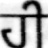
ਹੀ
